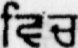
ਵਿਚ
